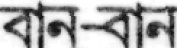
বান-বান
